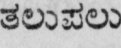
ತಲುಪಲು
